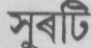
সুৰটি
